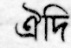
ঐদি
